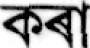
কৰা
